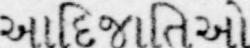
આદિજાતિઓ
